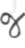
જ
